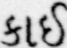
કાઈ
